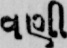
વણી
